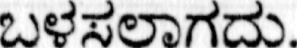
ಬಳಸಲಾಗದು.
